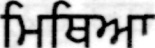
ਮਿਥਿਆ
